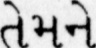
તેમને
